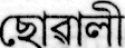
ছোৱালী
